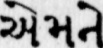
એમને
